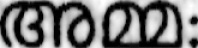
അമ്മ:
